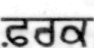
ਫ਼ਰਕ
